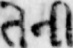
તેની
